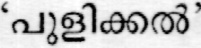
‘പുളിക്കല്‍’
